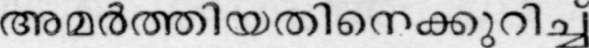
അമര്‍ത്തിയതിനെക്കുറിച്ച്
